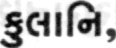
કુલાનિ,
